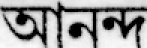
আনন্দ
